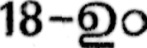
18-ഉം
